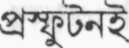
প্রস্ফুটনই
